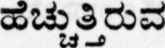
ಹೆಚ್ಚುತ್ತಿರುವ
